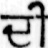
ਦੀ
